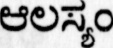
ಆಲಸ್ಯ೦
